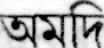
অমদি
